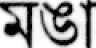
মঙা
